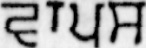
ਵਾਪਸ
